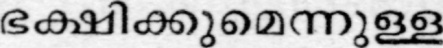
ഭക്ഷിക്കുമെന്നുള്ള
